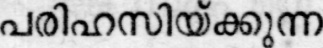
പരിഹസിയ്ക്കുന്ന
